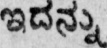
ಇದನ್ನು
